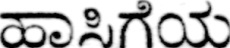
ಹಾಸಿಗೆಯ
